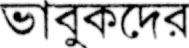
ভাবুকদের
